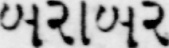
બરાબર
